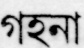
গহনা
